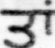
ਤਾਂ
